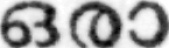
ഒരാ
